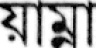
য়াম্না
